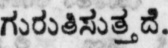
ಗುರುತಿಸುತ್ತದೆ.
